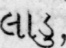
લાડુ,
